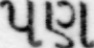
પણ
